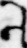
ને
